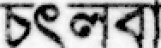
চৎলবা
